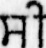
ਸੀ
